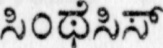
ಸಿಂಥೆಸಿಸ್
